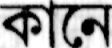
কানে
